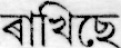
ৰাখিছে
